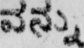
ವನ್ನು
